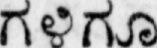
ಗಳಿಗೂ
